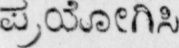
ಪ್ರಯೋಗಿಸಿ
